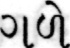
ગળે
